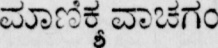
ಮಾಣಿಕ್ಯವಾಚಗಂ
